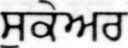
ਸੁਕੇਅਰ
